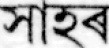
সাহৰ
